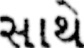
સાથે
